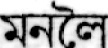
মনলৈ
